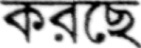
করছে
